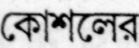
কোশলের
